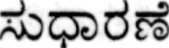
ಸುಧಾರಣೆ
